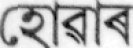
হোৱাৰ
